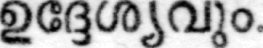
ഉദ്ദേശ്യവും.
